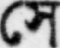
সে
